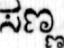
ಸಣ್ಣ
